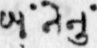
બંનેનું
